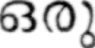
ഒരു
